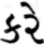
કરે
